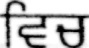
ਵਿਚ
